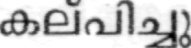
കല്പിച്ചു
